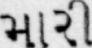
મારી
